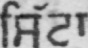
ਸਿੱਟਾ
